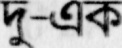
দু-এক
